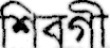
শিবগী
